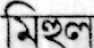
মিহুল
